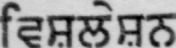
ਵਿਸ਼ਲੇਸ਼ਨ
